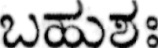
ಬಹುಶಃ
